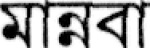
মান্নবা
